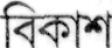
বিকাশ
